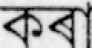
কৰা
